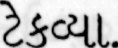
ટેકવ્યા.
